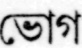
ভোগ
